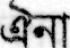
ঐনা
